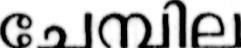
ചേമ്പില
